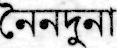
নৈনদুনা
